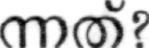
ന്നത്?
